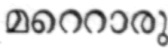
മറ്റൊരു
